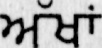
ਅੱਖਾਂ
